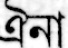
ঐনা
